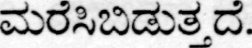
ಮರೆಸಿಬಿಡುತ್ತದೆ.
